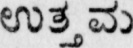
ಉತ್ತಮ
